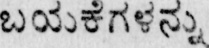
ಬಯಕೆಗಳನ್ನು
